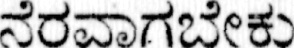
ನೆರವಾಗಬೇಕು
